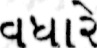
વધારે
